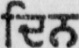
ਦਿਨ
